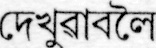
দেখুৱাবলৈ
